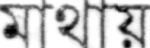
মাথায়
